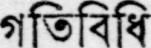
গতিবিধি
